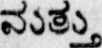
ಮತ್ತು
